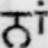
ਨਾਂ
